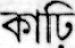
কাঢ়ি
